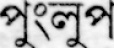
পুংলুপ
